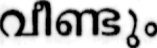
വീണ്ടും
